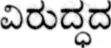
ವಿರುದ್ಧದ
